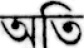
অতি
